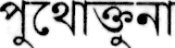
পুথোক্তুনা
